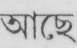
আছে
